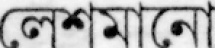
লেশমানো
